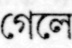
গেলে
